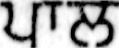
ਪਾਲ
